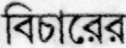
বিচারের
